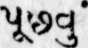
પૂછવું
